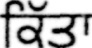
ਕਿੱਤਾ
